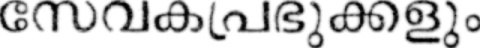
സേവകപ്രഭുക്കളും
